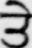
ਤੇ
